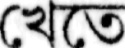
খেতে
